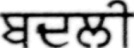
ਬਦਲੀ
